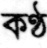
কণ্ঠ
